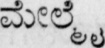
ಮೇಲ್ಮೈ
